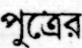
পুত্রের
